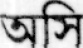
অসি
